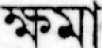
ক্ষমা
